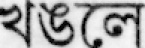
খঙলে
